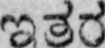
ಇತರ
